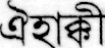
ঐহাক্কী
